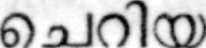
ചെറിയ
